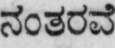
ನಂತರವೆ
